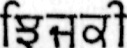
ਝਿਜਕੀ
